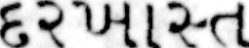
દરખાસ્ત
